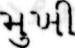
મુખી
